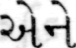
એને
